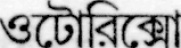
ওটোরিক্সো
